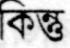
কিন্তু
